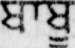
ਬਾਬੂ
